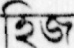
হিজ
